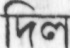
দিল
